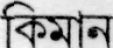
কিমান
